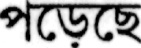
পড়েছে
